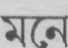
মনে
